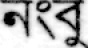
নংবু
